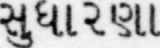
સુધારણા
